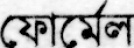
ফোর্মেল
